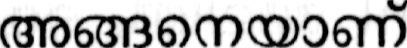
അങ്ങനെയാണ്
